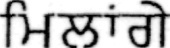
ਮਿਲਾਂਗੇ
